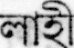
লাহী
